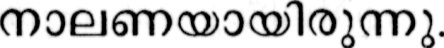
നാലണയായിരുന്നു.
